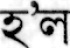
হ'ল
